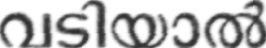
വടിയാല്‍
